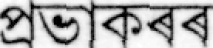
প্রভাকৰৰ
